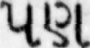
પણ
